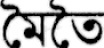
মৈতৈ
